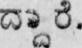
ದ್ದಾರೆ.
